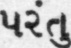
પરંતુ
